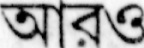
আরও
